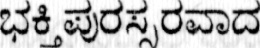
ಭಕ್ತಿಪುರಸ್ಸರವಾದ
